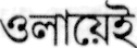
ওলায়েই
